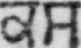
ਕਸ
